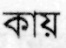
কায়
